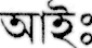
আইঃ
